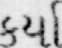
કર્યા
